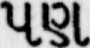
પણ
